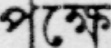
পক্ষে
